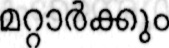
മറ്റാര്‍ക്കും
